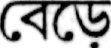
বেড়ে
